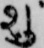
શું
